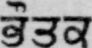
ਭੌਤਕ
